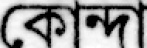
কোন্দা
